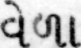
વેળા
